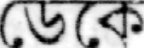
ডেকে
